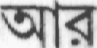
আর
